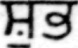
ਸ਼ੁਭ
